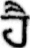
ਹੈ
